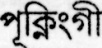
পূক্নিংগী
